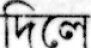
দিলে
